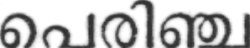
പെരിഞ്ച
